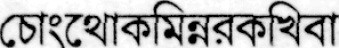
চোংথোকমিন্নরকখিবা
